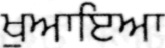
ਖੁਆਇਆ
